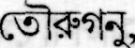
তৌরুগনু,
